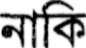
নাকি
